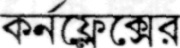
কর্নফ্লেক্সের
